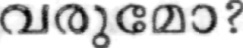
വരുമോ?
